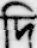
দি
